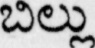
ಬಿಲ್ಲು
